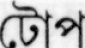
টোপ
